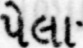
પેલા
